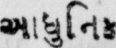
આધુનિક
